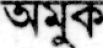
অমুক
